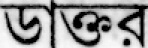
ডাক্তর
